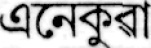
এনেকুৱা
